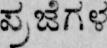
ಪ್ರಜೆಗಳ
